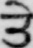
ਤੇ
